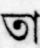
তা
